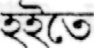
হইতে
